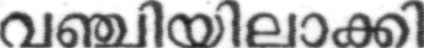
വഞ്ചിയിലാക്കി
